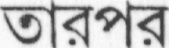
তারপর
